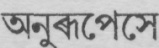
অনুৰূপেসে
